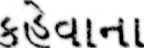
કહેવાના
